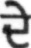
ਦੇ
